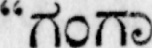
“ಗಂಗಾ
